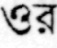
ওর
